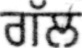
ਗੱਲ
